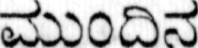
ಮುಂದಿನ
